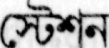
স্টেশন
